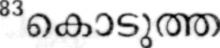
83കൊടുത്ത
